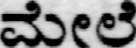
ಮೇಲೆ
